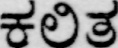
ಕಲಿತ
